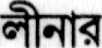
লীনার
